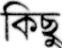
কিছু
